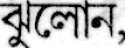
ঝুলোন,
